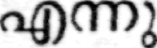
എന്നു
